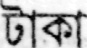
টাকা
